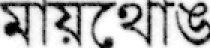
মায়থোঙ
